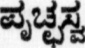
ಪೃಚ್ಛಸ್ವ
